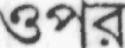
ওপর
